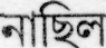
নাছিল
